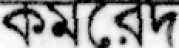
কমরেদ
